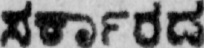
ಸರ್ಕಾರದ
